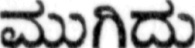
ಮುಗಿದು
